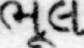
ભૂલ
